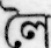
লৈ
